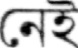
নেই
